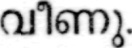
വീണു.
